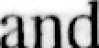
and
